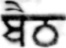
ਬੈਠ
